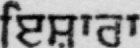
ਇਸ਼ਾਰਾ
